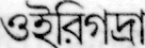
ওইরিগদ্রা
